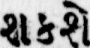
શકશે
